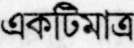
একটিমাত্র
